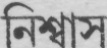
নিশ্বাস
